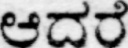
ಆದರೆ
